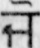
ਜੋ
